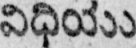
ವಿಧಿಯು
